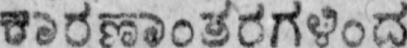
ಕಾರಣಾಂತರಗಳಿಂದ
